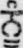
ਨੂੰ
